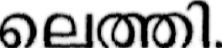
ലെത്തി.
